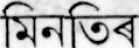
মিনতিৰ
